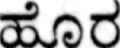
ಹೊರ
